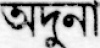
অদুনা
